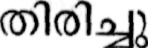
തിരിച്ചു
